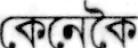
কেনেকৈ
